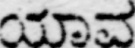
ಯಾವ
